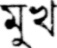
মুখ
